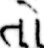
તો
